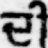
ਦੀ
